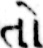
તો
